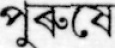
পুৰুষে
